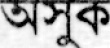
অসুক
